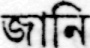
জানি
